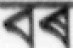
বৰ
